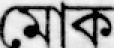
মোক
